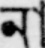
না
